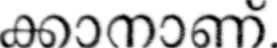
ക്കാനാണ്.
